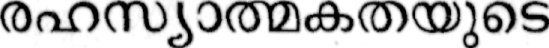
രഹസ്യാത്മകതയുടെ
